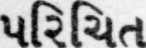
પરિચિત
